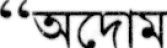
“অদো
